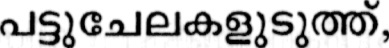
പട്ടുചേലകളുടുത്ത്,
